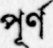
পূর্ণ
